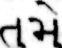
તમે
